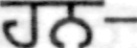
ਹਨ-
